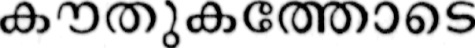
കൌതുകത്തോടെ
